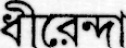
ধীরেন্দা
